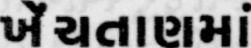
ખેંચતાણમાં
